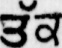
ਤੱਕ
